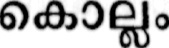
കൊല്ലം
